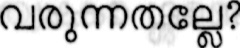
വരുന്നതല്ലേ?
